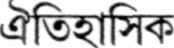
ঐতিহাসিক
